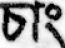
চাং
